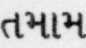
તમામ
